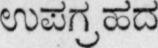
ಉಪಗ್ರಹದ
